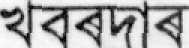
খবৰদাৰ
